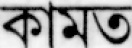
কামত
